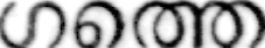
ഗത്തെ
